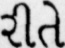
રીતે
